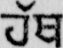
ਹੱਥ
